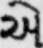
એ
